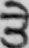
ਤੇ
